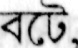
বটে,
